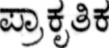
ಪ್ರಾಕೃತಿಕ
